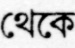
থেকে
